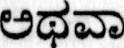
ಅಥವಾ
